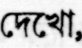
দেখো,
